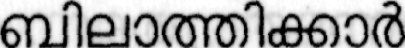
ബിലാത്തിക്കാര്‍
